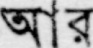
আর
